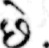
છે.
